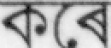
কৰে
